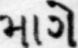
માગે
